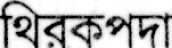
থিরকপদা
